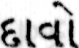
દાવો
